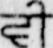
ਵੀ
